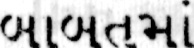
બાબતમાં
